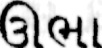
ઊભા
